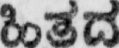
ಹಿತದ
